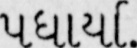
પધાર્યા.
